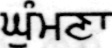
ਘੁੰਮਣਾ
